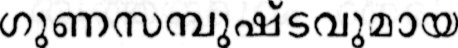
ഗുണസമ്പുഷ്ടവുമായ
